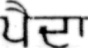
ਪੈਦਾ
